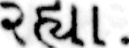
રહ્યા.
